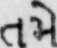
તમે
